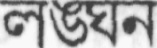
লঙ্ঘন
